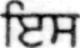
ਇਸ
